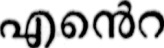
എന്റെ
